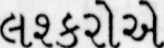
લશ્કરોએ
